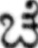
ಚೆ
